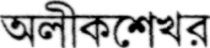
অলীকশেখর
